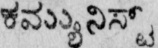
ಕಮ್ಯುನಿಸ್ಟ್
